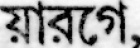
য়ারগে,
